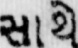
સાથે
